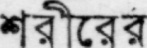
শরীরের
